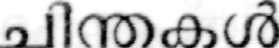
ചിന്തകള്‍
